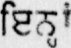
ਇਨ੍ਹਾਂ
